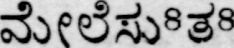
ಮೇಲೆಸು8ತ8
